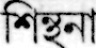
শিন্থনা
